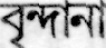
বৃন্দানা
